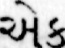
એક
